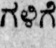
ಗಳಿಗೆ
